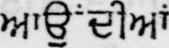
ਆਉਂਦੀਆਂ
